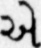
એ
